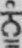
ਨੂੰ
